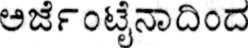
ಅರ್ಜೆಂಟೈನಾದಿಂದ
